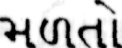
મળતો
